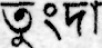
তুংদা
